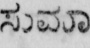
ಸುಮಾ
